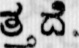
ತ್ತದೆ.
